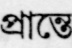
প্রান্তে
